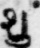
શું
